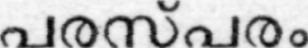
പരസ്പരം
